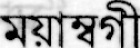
ময়াম্বগী
